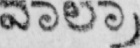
ವಾಲ್ರಾ
